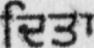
ਦਿਤਾ
